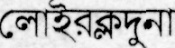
লোইরক্লদুনা
